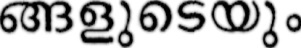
ങ്ങളുടെയും
